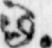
છે.
